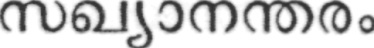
സഖ്യാനന്തരം
